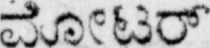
ಮೋಟರ್
